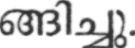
ങ്ങിച്ചു.
